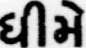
ધીમે
